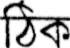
ঠিক
